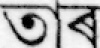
তাৰ
